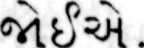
જોઈએ.
